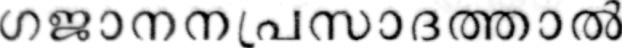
ഗജാനനപ്രസാദത്താല്‍
